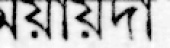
ময়ায়দা
